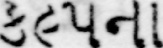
કલ્પના
